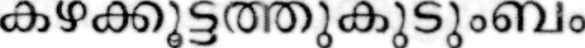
കഴക്കൂട്ടത്തുകുടുംബം
